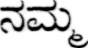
ನಮ್ಮ
